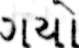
ગયો
